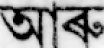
আৰু
